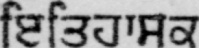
ਇਤਿਹਾਸਕ
